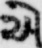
એ
